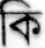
কি
